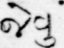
જેવું
